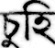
চুহি
